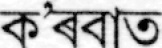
ক'ৰবাত
